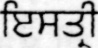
ਇਸਤ੍ਰੀ
